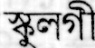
স্কুলগী
